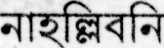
নাহল্লিবনি
